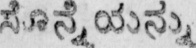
ಸೊನ್ನೆಯನ್ನು
